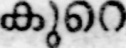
കുറെ
